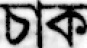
চাক
